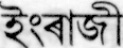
ইংৰাজী
